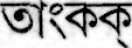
তাংকক্
